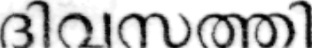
ദിവസത്തി
